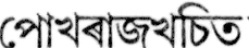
পোখৰাজখচিত
